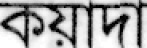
কয়াদা
